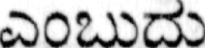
ಎಂಬುದು
